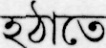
হঠাতে
